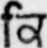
ਕਿ
